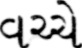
વચ્ચે
